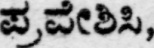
ಪ್ರವೇಶಿಸಿ,
